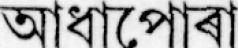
আধাপোৰা
